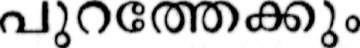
പുറത്തേക്കും
